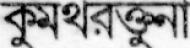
কুমথরক্তুনা
